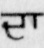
ਦਾ
